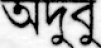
অদুবু
